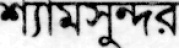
শ্যামসুন্দর
